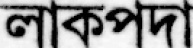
লাকপদা
